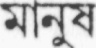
মানুষ
